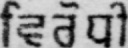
ਵਿਰੋਧੀ
